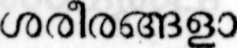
ശരീരങ്ങളാ
